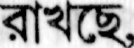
রাখছে,
